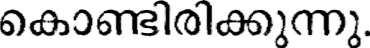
കൊണ്ടിരിക്കുന്നു.
